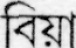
বিয়া
